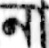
না
